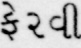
ફેરવી
